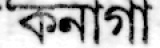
“কনাগা
